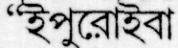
“ইপুরোইবা
